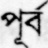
পূর্ব
